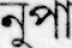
নুপা
